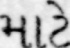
માટે
